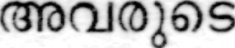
അവരുടെ
